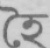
হৈ
